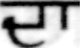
ਦਾ
